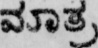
ಮಾತ್ರ
